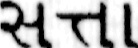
સત્તા
